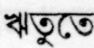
ঋতুতে
